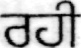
ਰਹੀ
